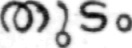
തുടം
